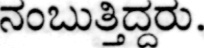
ನಂಬುತ್ತಿದ್ದರು.
